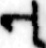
ન
